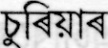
চুৰিয়াৰ
